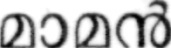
മാമന്‍
